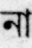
না
